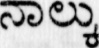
ನಾಲ್ಕು
